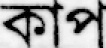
কাপ
